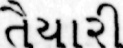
તૈયારી
